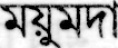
ময়ুমদা
